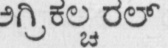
ಅಗ್ರಿಕಲ್ಚರಲ್
